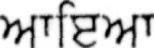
ਆਇਆ
